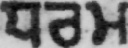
ਧਰਮ
